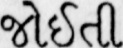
જોઈતી
